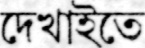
দেখাইতে
